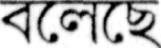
বলেছে
